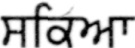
ਸਕਿਆ
